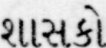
શાસકો
